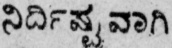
ನಿರ್ದಿಷ್ಟವಾಗಿ
